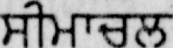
ਸੀਮਾਚਲ
